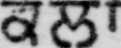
ਕਲਾ
